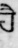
ਹੈ
